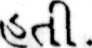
હતી.
